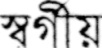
স্বর্গীয়
